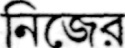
নিজের
